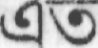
এত
